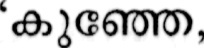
‘കുഞ്ഞേ,
